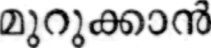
മുറുക്കാന്‍
